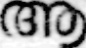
ആ
